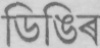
ডিঙিৰ
